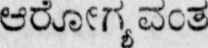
ಆರೋಗ್ಯವಂತ
